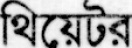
থিয়েটর
